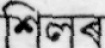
শিলৰ
